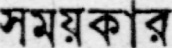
সময়কার
